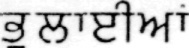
ਭੁਲਾਈਆਂ
